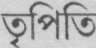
তৃপিতি
